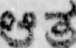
ಆತ
